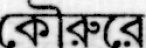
কৌরুরে
